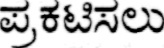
ಪ್ರಕಟಿಸಲು
